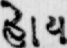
હોય
